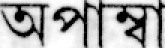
অপাম্বা
